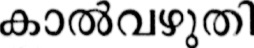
കാല്‍വഴുതി
